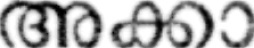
അക്കാ
